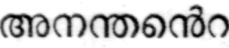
അനന്തന്റെ
